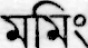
মমিং
